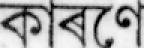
কাৰণে
